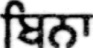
ਬਿਨਾ
